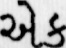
એક
